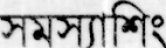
সমস্যাশিং
